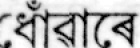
ধোঁৱাৰে
